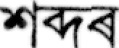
শব্দৰ
